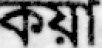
কয়া
